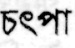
চৎপা
